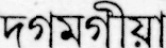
দগমগীয়া
